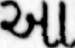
આ
